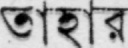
তাহার
